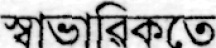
স্বাভাৱিকতে
